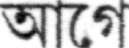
আগে
